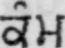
ਕੰਮ
